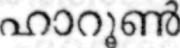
ഹാറൂണ്‍
